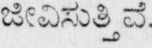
ಜೀವಿಸುತ್ತಿವೆ.
